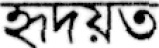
হৃদয়ত
